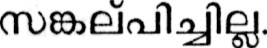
സങ്കല്പിച്ചില്ല.
